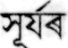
সূর্যৰ
